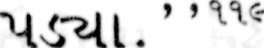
પડ્યા."૧૧૯
